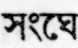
সংঘে
